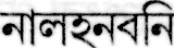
নালহনবনি
